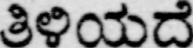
ತಿಳಿಯದೆ
